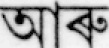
আৰু
